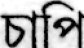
চাপি
